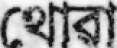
থোৱা
